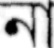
না
